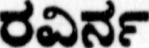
ರವಿರ್ನ
